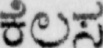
ಕೆಲಸ
